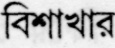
বিশাখার
